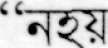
"নহয়
